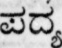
ಪದ್ಯ
